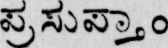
ಪ್ರಸುಪ್ತಾಂ
